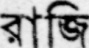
রাজি
